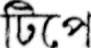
টিপে
